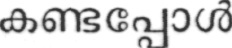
കണ്ടപ്പോള്‍
